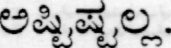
ಅಷ್ಟಿಷ್ಟಲ್ಲ.
